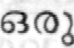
ഒരു
